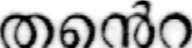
തന്റെ
